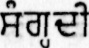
ਸੰਗ੍ਹਦੀ
